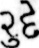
રુદે
